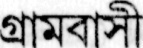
গ্রামবাসী
